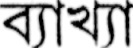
ব্যাখ্যা
